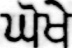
ਘੋਖੇ
